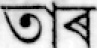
তাৰ
